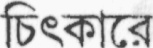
চিত্কারে
